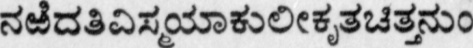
ನಱದತಿವಿಸ್ಮಯಾಕುಲೀಕೃತಚಿತ್ತನುಂ
